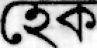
হেক
